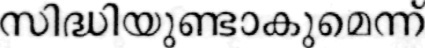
സിദ്ധിയുണ്ടാകുമെന്ന്
